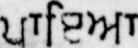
ਪਾਇਆ
